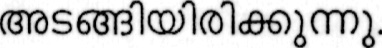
അടങ്ങിയിരിക്കുന്നു.
